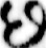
છ
